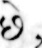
છે,
